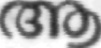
ആ
